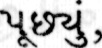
પૂછ્યું,
